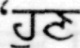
'ਹੁਣ
